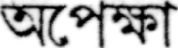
অপেক্ষা
